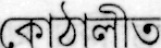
কোঠালীত
